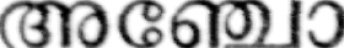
അഞ്ചോ
